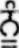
ਨੂੰ
